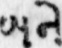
બને
